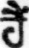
ਹੈਂ
